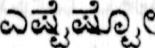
ಎಷ್ಟೆಷ್ಟೋ
